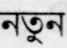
নতুন
